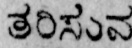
ತರಿಸುವ
